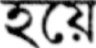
হয়ে
